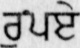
ਰੁਪਏ
